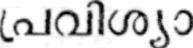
പ്രവിശ്യാ
